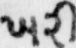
ખરી
